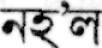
নহ'ল
